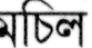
মচিল
